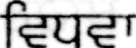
ਵਿਧਵਾ
